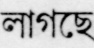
লাগছে
